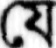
যে
